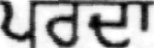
ਪਰਦਾ
